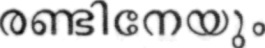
രണ്ടിനേയും
